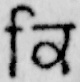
ਕਿ
